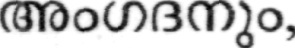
അംഗദനും,
